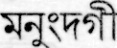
মনুংদগী
